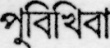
পুবিখিবা
